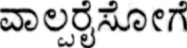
ವಾಲ್ಪರೈಸೋಗೆ
